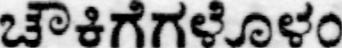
ಚೌಕಿಗೆಗಳೊಳಂ
